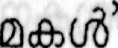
മകള്‍'
